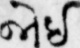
જોઈ
